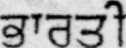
ਭਾਰਤੀ
